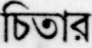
চিতার
